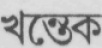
খন্তেক
